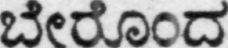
ಬೇರೊಂದ
